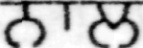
ਨਾਲ
